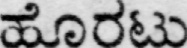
ಹೊರಟು
